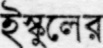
ইস্কুলের
